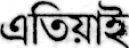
এতিয়াই
